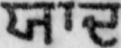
ਯਾਦ
